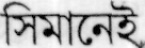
সিমানেই
